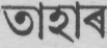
তাহাৰ
